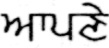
ਆਪਣੇ
